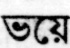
ভয়ে
